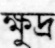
ক্ষুদ্র
